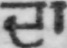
ਦਾ
